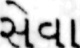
સેવા
